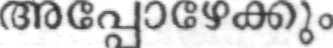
അപ്പോഴേക്കും
